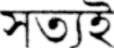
সত্যই
